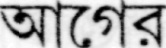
আগের
